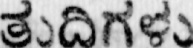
ತುದಿಗಳು
